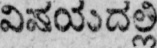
ವಿಷಯದಲ್ಲಿ
